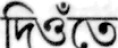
দিওঁতে
